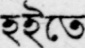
হইতে
